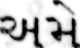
અમે
